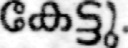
കേട്ടു.
